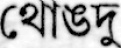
থোঙদু
